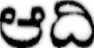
ಆದಿ
